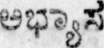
ಅಭ್ಯಾಸ
